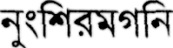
নুংশিরমগনি
